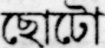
ছোটো
